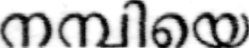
നമ്പിയെ
